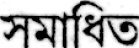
সমাধিত
